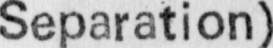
Seperation)
